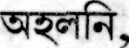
অহলনি,
